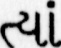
ત્યાં
